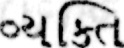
વ્યક્તિ
